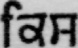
ਕਿਸ
